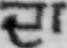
ਦਾ
